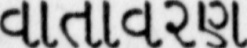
વાતાવરણ
